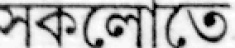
সকলোতে
